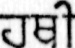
ਹਥੀ
